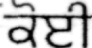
ਕੋਈ
